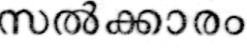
സല്‍ക്കാരം
